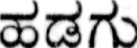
ಹಡಗು
